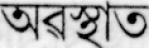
অৱস্থাত
